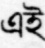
এই
